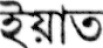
ইয়াত
